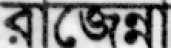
রাজেন্না
